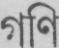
গণি
